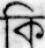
কি
